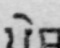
ਪੇਸ਼
